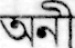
অনী
